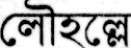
লৌহল্লে
